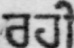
ਰਹੀ
